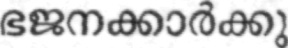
ഭജനക്കാര്‍ക്കു
